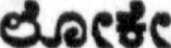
ಲೋಕೇ
